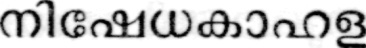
നിഷേധകാഹള
